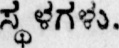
ಸ್ಥಳಗಳು.
